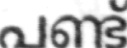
പണ്ട്
